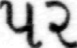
પર
